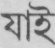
যাই
